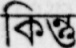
কিন্তু
